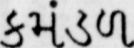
કમંડળ
